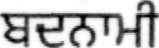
ਬਦਨਾਮੀ
